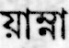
য়াম্না
